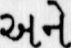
અને
